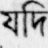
যদি
